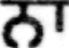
ਨਾ
